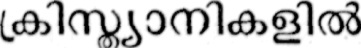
ക്രിസ്ത്യാനികളില്‍
